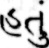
હતું
